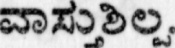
ವಾಸ್ತುಶಿಲ್ಪ.
